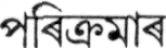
পৰিক্রমাৰ
